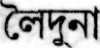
লৈদুনা
